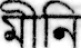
মীনি
